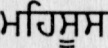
ਮਹਿਸੂਸ
